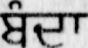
ਬੰਦਾ
